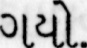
ગયો.
